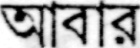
আবার
